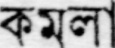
কমলা
